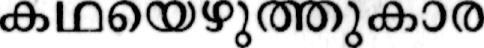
കഥയെഴുത്തുകാര
